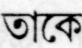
তাকে
